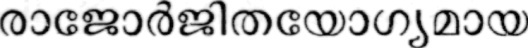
രാജോര്‍ജിതയോഗ്യമായ
